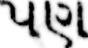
પણ
